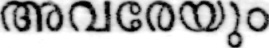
അവരേയും
